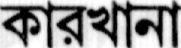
কারখানা
